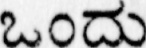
ಒಂದು
